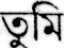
তুমি
